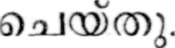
ചെയ്തു.
